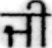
ਜੀ
